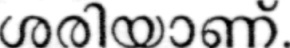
ശരിയാണ്.
